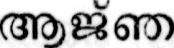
ആജ്ഞ
